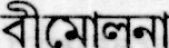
বীমোলনা
